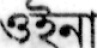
ওইনা
